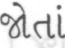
જોતાં
